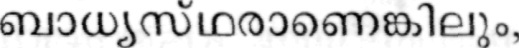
ബാധ്യസ്ഥരാണെങ്കിലും,
